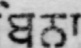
ਬਿਨਾ
